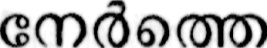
നേര്‍ത്തെ
